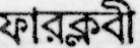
ফারক্লবী
